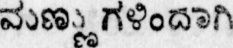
ಮಣ್ಣುಗಳಿಂದಾಗಿ
